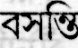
বসন্তি
